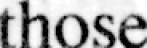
those
